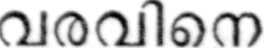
വരവിനെ
